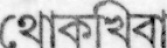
থোকখিবা
